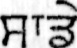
ਸਾਡੇ
